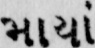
માયાં
